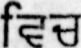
ਵਿਚ
